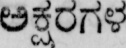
ಅಕ್ಷರಗಳ
